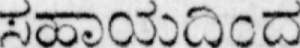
ಸಹಾಯದಿಂದ
